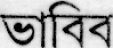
ভাবিব
